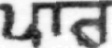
ਪਾਰ
